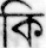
কি
